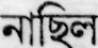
নাছিল
